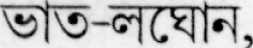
ভাত-লঘোন,
